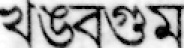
খঙবগু
